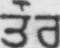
ਤੌਰ
